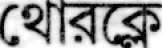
থোরক্লে
